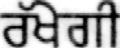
ਰੱਖੇਗੀ
